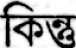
কিন্তু
